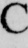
C
